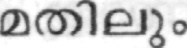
മതിലും
